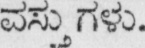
ವಸ್ತುಗಳು.
